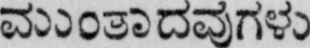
ಮುಂತಾದವುಗಳು
